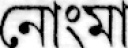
নোংমা
